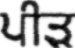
ਪੀੜ
